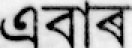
এবাৰ
